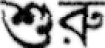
শুরু
